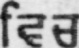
ਵਿਚ
